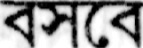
বসবে
